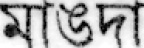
মাঙদা
